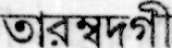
তারম্বদগী
